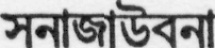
সনাজাউবনা
